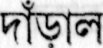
দাঁড়াল
